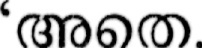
‘അതെ.
